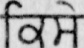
ਕਿਸੇ
